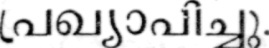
പ്രഖ്യാപിച്ചു.
